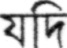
যদি
